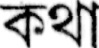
কথা
